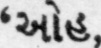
'ઓહ,
